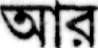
আর
